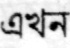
এখন
